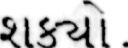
શક્યો.
